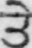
ਤੇ
